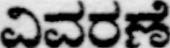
ವಿವರಣೆ
